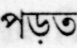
পড়ত
